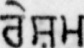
ਰੇਸ਼ਮ
